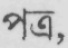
পত্র,
